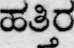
ಹತ್ತಿರ
